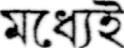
মধ্যেই
